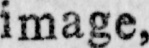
image,
